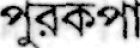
পুরকপা
